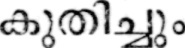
കുതിച്ചും
